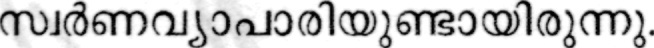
സ്വര്‍ണവ്യാപാരിയുണ്ടായിരുന്നു.
